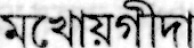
মখোয়গীদা
